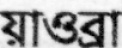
য়াওব্রা
